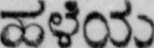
ಹಳೆಯ
